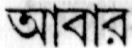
আবার
